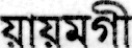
য়ায়মগী
